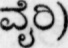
ವೈರಿ)
